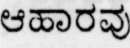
ಆಹಾರವು
